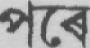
পৰে
